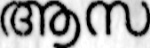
ആസ
